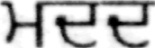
ਮਦਦ
